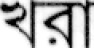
খরা
